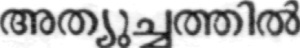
അത്യുച്ചത്തില്‍
